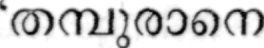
'തമ്പുരാനെ
